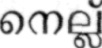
നെല്ല്
